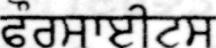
ਫੋਰਸਾਈਟਸ
